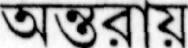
অন্তরায়
